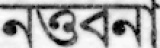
নত্তবনা
